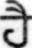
ਹੈ
